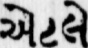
એટલે
